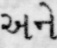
અને
